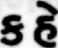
કહે
